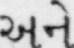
અને
